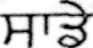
ਸਾਡੇ
